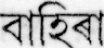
বাহিৰা
